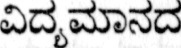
ವಿದ್ಯಮಾನದ
